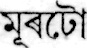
মূৰটো
